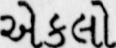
એકલો
